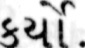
કર્યો.
